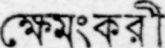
ক্ষেমংকরী
